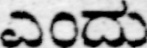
ಎಂದು
